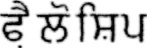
ਫ਼ੈਲੋਸ਼ਿਪ
